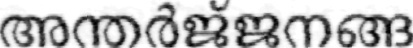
അന്തര്‍ജ്ജനങ്ങ
